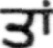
ਤਾਂ
